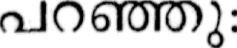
പറഞ്ഞു:
